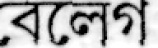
বেলেগ
